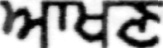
ਆਖਣ
